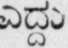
ಎದ್ದು
